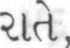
રાતે,
